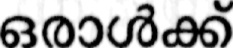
ഒരാള്‍ക്ക്
